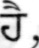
ਹੈ,
